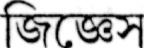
জিজ্ঞেস
